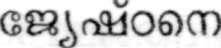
ജ്യേഷ്ഠനെ
